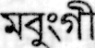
মবুংগী
